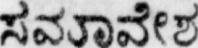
ಸಮಾವೇಶ
